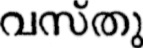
വസ്തു
